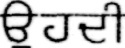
ਉਹਦੀ
